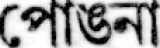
পোঙনা
